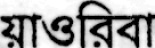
য়াওরিবা
